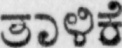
ತಾಳಿಕೆ
